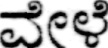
ವೇಳೆ
